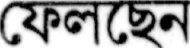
ফেলছেন
